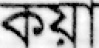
কয়া
